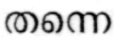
തന്നെ
